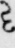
દે
